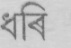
ধৰি
